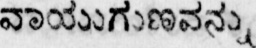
ವಾಯುಗುಣವನ್ನು
